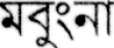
মবুংনা
